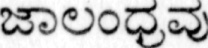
ಜಾಲಂಧ್ರವು
